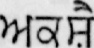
ਅਕਸ਼ੈ
